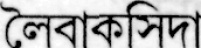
লৈবাকসিদা
